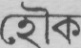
হৌক
